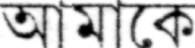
আমাকে
